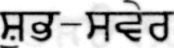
ਸ਼ੁਭ-ਸਵੇਰ
